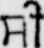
ਸੀ
